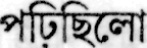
পঢ়িছিলো
